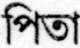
পিতা
